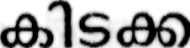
കിടക്ക
